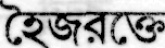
হৈজরক্তে
